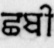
ਛਬੀ
